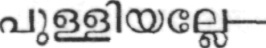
പുള്ളിയല്ലേ-
